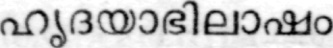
ഹൃദയാഭിലാഷം
